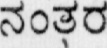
ನಂತರ
